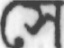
সে
